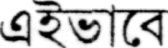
এইভাবে
